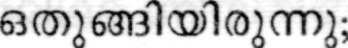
ഒതുങ്ങിയിരുന്നു;
